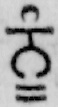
ਨੂੰ
